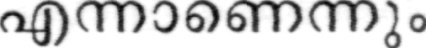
എന്നാണെന്നും
